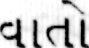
વાતો
